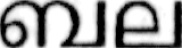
ബല
